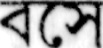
বসে
